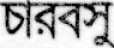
চারবসু
